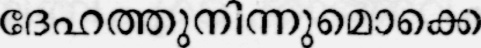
ദേഹത്തുനിന്നുമൊക്കെ
